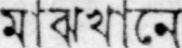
মাঝখানে
